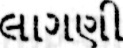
લાગણી
